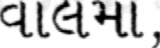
વાલમા,
